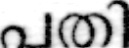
പതി
